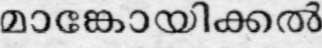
മാങ്കോയിക്കല്‍
